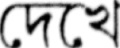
দেখে
